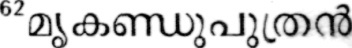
62മൃകണ്ഡുപുത്രന്‍
